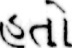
હતો
